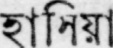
হাসিয়া
